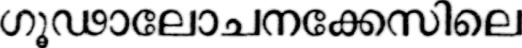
ഗൂഢാലോചനക്കേസിലെ
